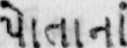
પોતાનાં
